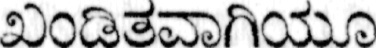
ಖಂಡಿತವಾಗಿಯೂ
